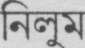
নিলুম
